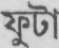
ফুটা
